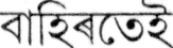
বাহিৰতেই
